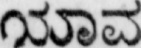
ಯಾವ
